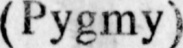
(Pygmy)
